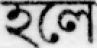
হলে
